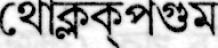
থোক্লক্পগুম
